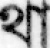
থা
